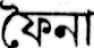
ফৈনা
